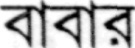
বাবার
